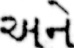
અને
